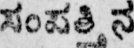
ಸಂಪತ್ತಿನ
